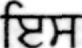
ਇਸ
